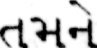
તમને
